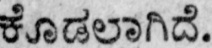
ಕೊಡಲಾಗಿದೆ.
